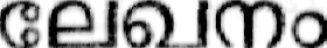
ലേഖനം
